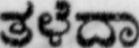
ತಳೆದಾ
